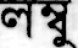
লম্বু
